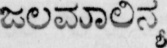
ಜಲಮಾಲಿನ್ಯ
